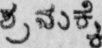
ಶ್ರಮಕ್ಕೆ
